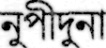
নুপীদুনা
